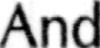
And
